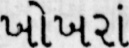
ખોખરાં
